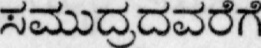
ಸಮುದ್ರದವರೆಗೆ
